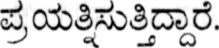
ಪ್ರಯತ್ನಿಸುತ್ತಿದ್ದಾರೆ.
